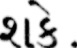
શકે.
